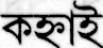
কহ্নাই
